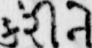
કેરીને
